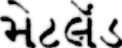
મેટલૅડ
